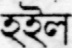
হইল
